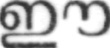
ഈ
